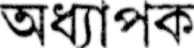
অধ্যাপক
